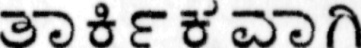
ತಾರ್ಕಿಕವಾಗಿ
